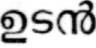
ഉടന്‍
